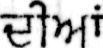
ਦੀਆਂ
